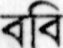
ববি
